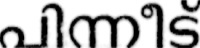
പിന്നീട്
